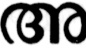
അ
